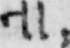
ના,
